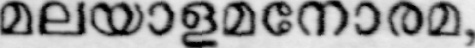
മലയാളമനോരമ,
